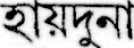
হায়দুনা
